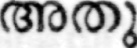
അതു
